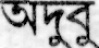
অদুবু
